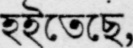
হইতেছে,
